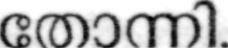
തോന്നി.
